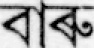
বাৰু
